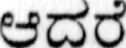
ಆದರೆ
